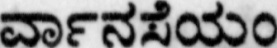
ರ್ವಾನಸೆಯಂ
